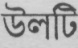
উলটি
